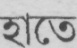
হাতে
